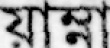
য়াম্না
